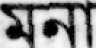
মনা
